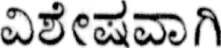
ವಿಶೇಷವಾಗಿ
